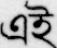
এই
